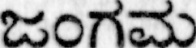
ಜಂಗಮ
